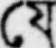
যে
